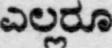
ಎಲ್ಲರೂ
